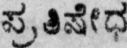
ಪ್ರತಿಷೇಧ
